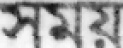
সময়
